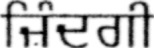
ਜ਼ਿੰਦਗੀ
